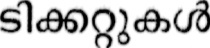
ടിക്കറ്റുകള്‍
